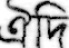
ঐদি
